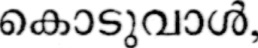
കൊടുവാള്‍,
